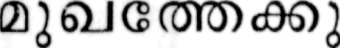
മുഖത്തേക്കു
